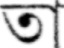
তা
